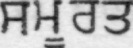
ਸਮੂਰਤ
